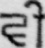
ਵੀ
